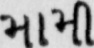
મામી
